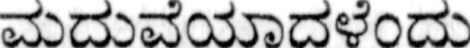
ಮದುವೆಯಾದಳೆಂದು
